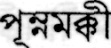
পূম্নমক্কী
